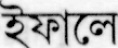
ইফালে
